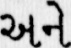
અને
